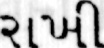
રાખી
